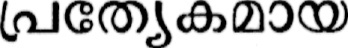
പ്രത്യേകമായ
